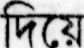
দিয়ে
